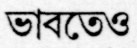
ভাবতেও
